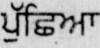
ਪੁੱਛਿਆ
